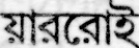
য়াররোই
